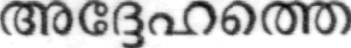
അദ്ദേഹത്തെ
